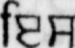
ਇਸ
